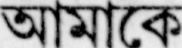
আমাকে
